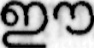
ഈ
